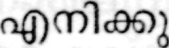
എനിക്കു
